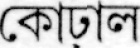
কোঢ়াল
